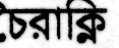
চৈরাক্নি
